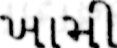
ખામી
